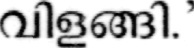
വിളങ്ങി.'
